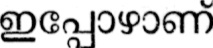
ഇപ്പോഴാണ്
